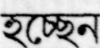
হচ্ছেন
